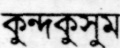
কুন্দকুসুম
